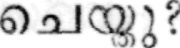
ചെയ്തു?
